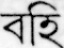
বহি
